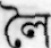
লৈ
